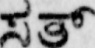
ಸತ್
